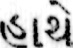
હાથે
